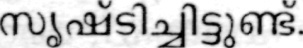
സൃഷ്ടിച്ചിട്ടുണ്ട്.
